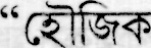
“হৌজিক
